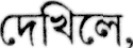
দেখিলে,
